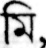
মি,
